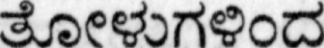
ತೋಳುಗಳಿಂದ
